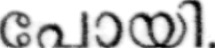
പോയി.
